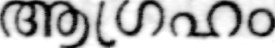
ആഗ്രഹം
